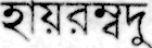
হায়রম্বদু
